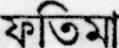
ফতিমা
